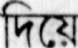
দিয়ে
